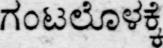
ಗಂಟಲೊಳಕ್ಕೆ
